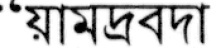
“য়ামদ্রবদা
